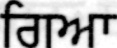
ਗਿਆ
